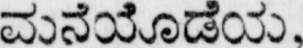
ಮನೆಯೊಡೆಯ,
